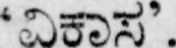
‘ವಿಕಾಸ’.
